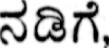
ನಡಿಗೆ,
